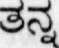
ತನ್ನ
